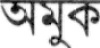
অমুক
